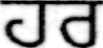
ਹਰ
